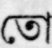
তো
